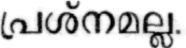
പ്രശ്നമല്ല.
